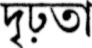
দৃঢ়তা
